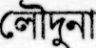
লৌদুনা
